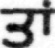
ਤਾਂ
